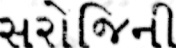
સરોજિની
